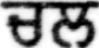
ਚਲ
